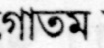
গোতম
